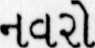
નવરો
